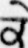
ਕੇ
